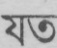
যত
